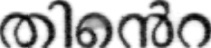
തിന്റെ
